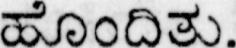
ಹೊಂದಿತು.
